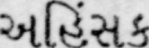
અહિંસક
